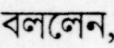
বললেন,
